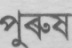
পুৰুষ
